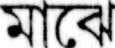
মাঝে
